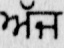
ਅੱਜ
